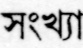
সংখ্যা
